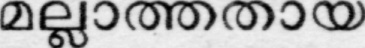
മല്ലാത്തതായ
